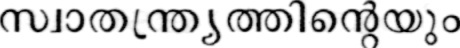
സ്വാതന്ത്ര്യത്തിന്റെയും
